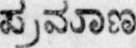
ಪ್ರಮಾಣ
